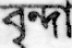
বৃন্দা
